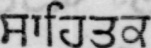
ਸਾਹਿਤਕ
